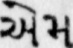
એમ
